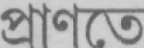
প্ৰাণতে
